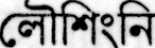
লৌশিংনি
